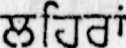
ਲਹਿਰਾਂ
